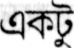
একটু
